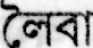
লৈবা
